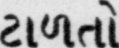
ટાળતો
